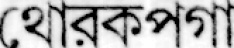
থোরকপগা
